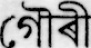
গৌৰী
